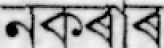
নকৰাৰ
